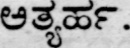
ಅತ್ಯರ್ಹ.
